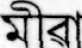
মীৱা
